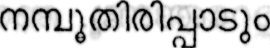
നമ്പൂതിരിപ്പാടും
